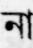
না
